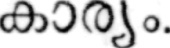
കാര്യം.
